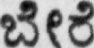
ಬೇರೆ
